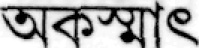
অকস্মাৎ
